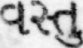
વસ્તુ
